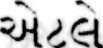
એટલે
